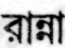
রান্না
